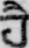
ਹੈ
